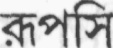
রূপসি
